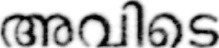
അവിടെ
